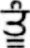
ਤੂੰ
